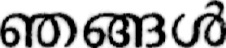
ഞങ്ങള്‍
